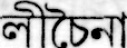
লীচৈনা
